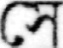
সে
